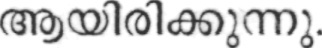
ആയിരിക്കുന്നു.
